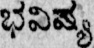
ಭವಿಷ್ಯ
